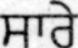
ਸਾਰੇ
